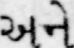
અને
